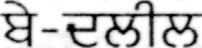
ਬੇ-ਦਲੀਲ
